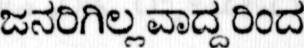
ಜನರಿಗಿಲ್ಲವಾದ್ದರಿಂದ
